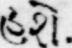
હશે.
